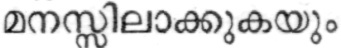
മനസ്സിലാക്കുകയും
